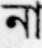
না
